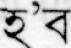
হ'ব
